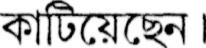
কাটিয়েছেন।
